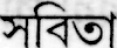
সবিতা
